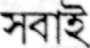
সবাই
